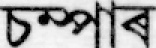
চম্পাৰ
